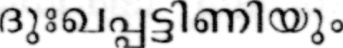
ദുഃഖപ്പട്ടിണിയും
